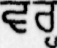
ਵਰ੍ਹ
